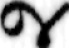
જ
